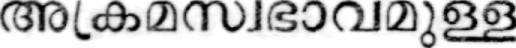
അക്രമസ്വഭാവമുള്ള
